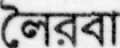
লৈরবা
